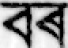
বৰ
